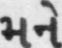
મને
